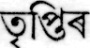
তৃপ্তিৰ
